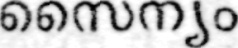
സൈന്യം
